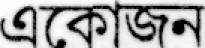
একোজন
